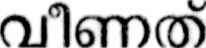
വീണത്
